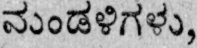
ಮಂಡಳಿಗಳು,
